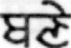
ਬਣੇ
